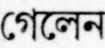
গেলেন
